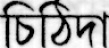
চিঠিদা
